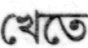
খেতে
